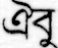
ঐবু
